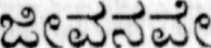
ಜೀವನವೇ
